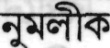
নুমলীক
